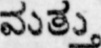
ಮತ್ತು
